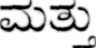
ಮತ್ತು
